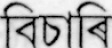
বিচাৰি
